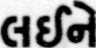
લઈને
